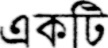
একটি
